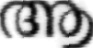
ആ
